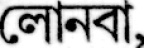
লোনবা,
